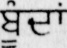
ਬੂੰਦਾਂ
